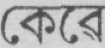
কেৱে
